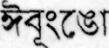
ঈবূংঙো
